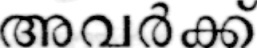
അവര്‍ക്ക്
